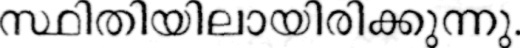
സ്ഥിതിയിലായിരിക്കുന്നു.
